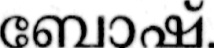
ബോഷ്.
